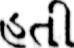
હતી
